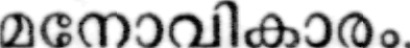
മനോവികാരം.
